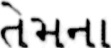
તેમના
